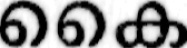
കൈ
